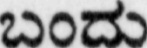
ಬಂದು
